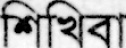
শিখিবা
